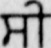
ਸੀ
